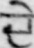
ਦੇ
